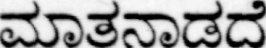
ಮಾತನಾಡದೆ
